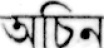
অচিন
